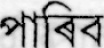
পাৰিব
